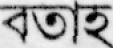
বতাহ
